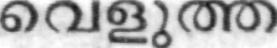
വെളുത്ത
